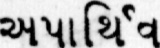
અપાર્થિવ
